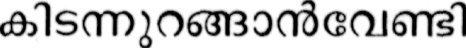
കിടന്നുറങ്ങാന്‍വേണ്ടി
